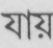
যায়
